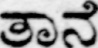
ತಾನೆ
